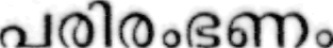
പരിരംഭണം
